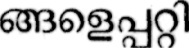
ങ്ങളെപ്പറ്റി
